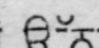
ਉੱਨਾ
